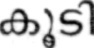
കൂടി
